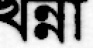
খন্না
